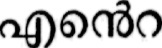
എന്റെ
